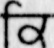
ਕਿ
